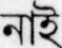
নাই
